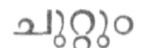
ചുറ്റും
